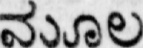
ಮೂಲ
